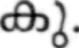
കു.
